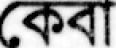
কেবা
